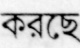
করছে
